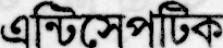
এন্টিসেপটিক
